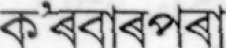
ক'ৰবাৰপৰা
